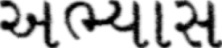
અભ્યાસ
